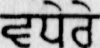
ਵਧੇਰੇ
